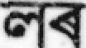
লৰ
